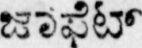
ಜಾಫೆಟ್
